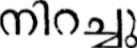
നിറച്ചു
